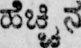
ಹೆಚ್ಚಿನ
